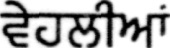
ਵੇਹਲੀਆਂ
